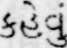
કહેવું
